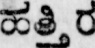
ಹತ್ತಿರ
